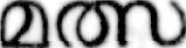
മത്സ
